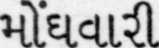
મોંઘવારી
